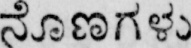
ನೊಣಗಳು
